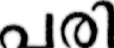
പരി
